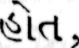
હોત,
